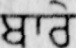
ਬਾਰੇ
